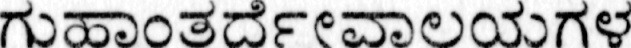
ಗುಹಾಂತರ್ದೇವಾಲಯಗಳ
